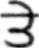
ਤੇ
